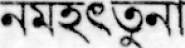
নমহৎতুনা
